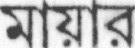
মায়ার
